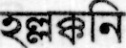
হল্লক্কনি
